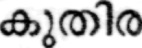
കുതിര
